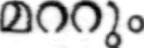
മററും
